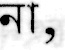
না,
